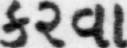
કરવા
